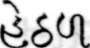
હેઠળ
